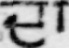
ਦਾ
